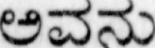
ಅವನು
